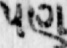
પણ
